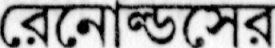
রেনোল্ডসের
